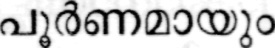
പൂര്‍ണമായും
